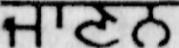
ਜਾਣਨ
